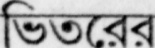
ভিতরের
